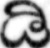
ಡಿ
